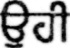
ਉਹੀ
